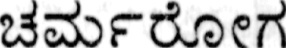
ಚರ್ಮರೋಗ
